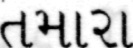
તમારા
